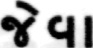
જેવા
